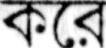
করে
